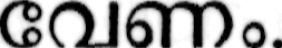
വേണം.
